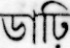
ডাঢ়ি
